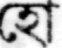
হো
